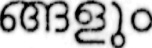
ങ്ങളും
